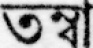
তম্বা
